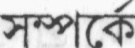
সম্পর্কে
